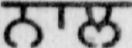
ਨਾਲ
